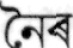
নৈৰ
